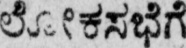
ಲೋಕಸಭೆಗೆ
